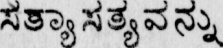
ಸತ್ಯಾಸತ್ಯವನ್ನು
